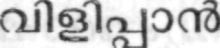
വിളിപ്പാന്‍
